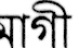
মাগী
